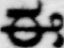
ಈ
